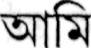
আমি
